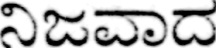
ನಿಜವಾದ
